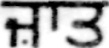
ਜ਼ਾਤ
